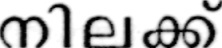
നിലക്ക്
